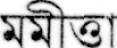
মমীত্তা
